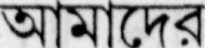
আমাদের
